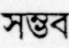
সম্ভব
